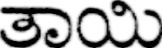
ತಾಯಿ
